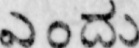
ಎಂದು
